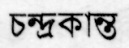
চন্দ্রকান্ত
